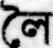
লৈ
